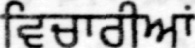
ਵਿਚਾਰੀਆਂ
